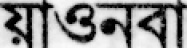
য়াওনবা
